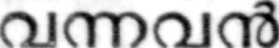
വന്നവന്‍
